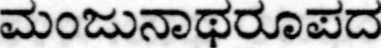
ಮಂಜುನಾಥರೂಪದ
